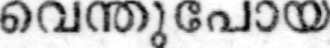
വെന്തുപോയ
